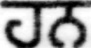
ਹਨ
